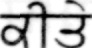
ਕੀਤੇ
